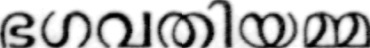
ഭഗവതിയമ്മ
